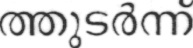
ത്തുടര്‍ന്ന്
